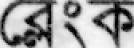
ব্লেংক
